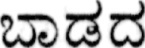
ಬಾಡದ
